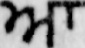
ਆ
